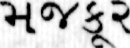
મજકૂર
